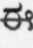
ಈ
